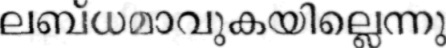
ലബ്ധമാവുകയില്ലെന്നു
